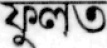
ফুলত
